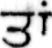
ਤਾਂ
